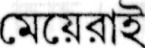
মেয়েরাই
